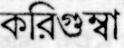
করিগুম্বা
